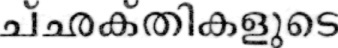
ച്ഛക്തികളുടെ
